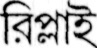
রিপ্লাই
